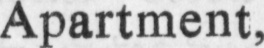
Apartment,
